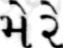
મેરે
